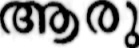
ആരു
